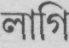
লাগি
